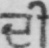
ਦੀ
